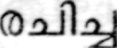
രചിച്ച
